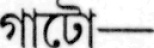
গাটো-
